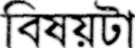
বিষয়টা
